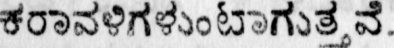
ಕರಾವಳಿಗಳುಂಟಾಗುತ್ತವೆ.
